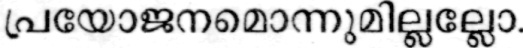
പ്രയോജനമൊന്നുമില്ലല്ലോ.
